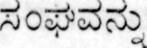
ಸಂಘವನ್ನು
